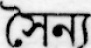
সৈন্য
